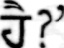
ਹੈ?'
